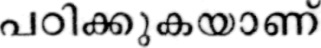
പഠിക്കുകയാണ്
